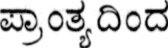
ಪ್ರಾಂತ್ಯದಿಂದ
